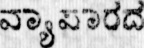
ವ್ಯಾಪಾರದ
